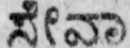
ಸೇವಾ
